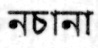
নচানা
